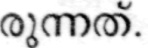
രുന്നത്.
